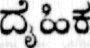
ದೈಹಿಕ
